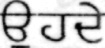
ਉਹਦੇ
